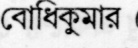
বোধিকুমার
